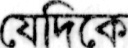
যেদিকে
